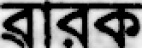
ৱারক
